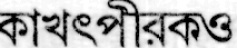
কাখৎপীরকও
